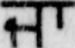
ਜਾ
